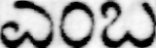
ಎಂಬ
